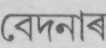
বেদনাৰ
